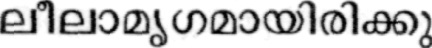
ലീലാമൃഗമായിരിക്കു
